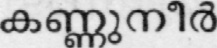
കണ്ണുനീര്‍
